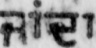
ਜਾਂਦਾ
